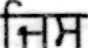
ਜਿਸ
